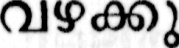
വഴക്കു
